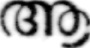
ആ
